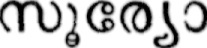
സൂര്യോ
